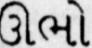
ઊભો
